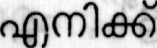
എനിക്ക്
